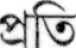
প্রতি
